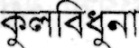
কুলবিধুনা
